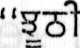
''ਝੂਠੀ
